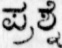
ಪ್ರಶ್ನೆ
